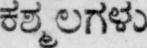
ಕಶ್ಮಲಗಳು
